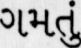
ગમતું
